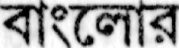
বাংলোর
